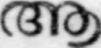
ആ
